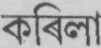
কৰিলা
